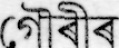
গৌৰীৰ
